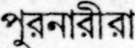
পুরনারীরা
